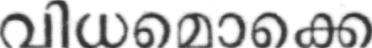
വിധമൊക്കെ
